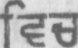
ਵਿਚ
